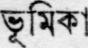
ভূমিকা
